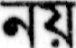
নয়
